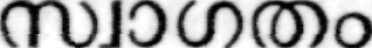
സ്വാഗതം
